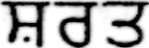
ਸ਼ਰਤ
